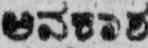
ಅವಕಾಶ
